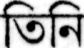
তিনি
